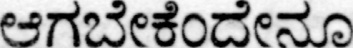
ಆಗಬೇಕೆಂದೇನೂ
